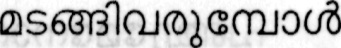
മടങ്ങിവരുമ്പോള്‍
